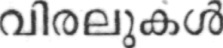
വിരലുകള്‍
